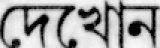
দেখোন
